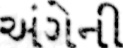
અંગેની
